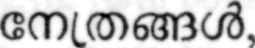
നേത്രങ്ങള്‍,
